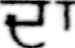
ਦਾ
